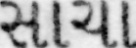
સાચા
